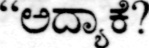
"ಅದ್ಯಾಕೆ?
